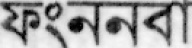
ফংননবা
